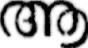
ആ
